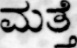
ಮತ್ತೆ
